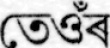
তেওঁৰ
